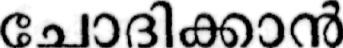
ചോദിക്കാന്‍
